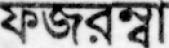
ফজরম্বা
